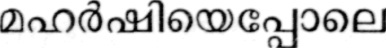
മഹര്‍ഷിയെപ്പോലെ
